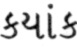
ક્યાંક
